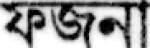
ফজনা
